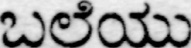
ಬಲೆಯು
